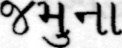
જમુના
